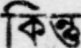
কিন্তু
